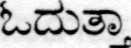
ಓದುತ್ತಾ
